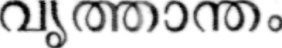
വൃത്താന്തം
